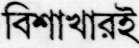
বিশাখারই
